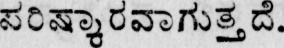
ಪರಿಷ್ಕಾರವಾಗುತ್ತದೆ.
